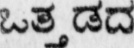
ಒತ್ತಡದ
